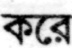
করে
